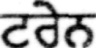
ਟਰੇਨ
